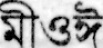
মীওঈ
